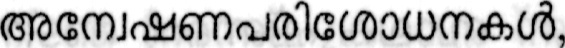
അന്വേഷണപരിശോധനകള്‍,
